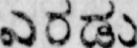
ಎರಡು
